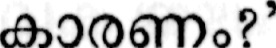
കാരണം?'
